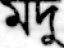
মদু
